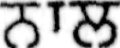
ਨਾਲ
